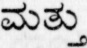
ಮತ್ತು
